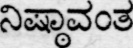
ನಿಷ್ಠಾವಂತ
